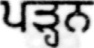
ਪੜ੍ਹਨ
